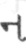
ન
